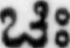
ಚಿಃ
